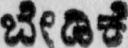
ಬೇಡಿಕೆ
